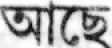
আছে
